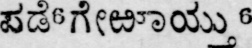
ಪಡೆ6ಗೇಱಾಯ್ತು6
